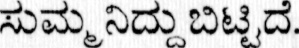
ಸುಮ್ಮನಿದ್ದುಬಿಟ್ಟಿದೆ.
